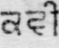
ਕਵੀ
